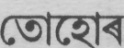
তোহোৰ
